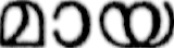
മായ
